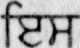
ਇਸ
